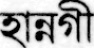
হান্নগী
